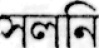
সলনি
